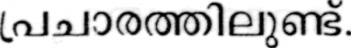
പ്രചാരത്തിലുണ്ട്.
